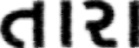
તારા
